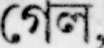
গেল,
